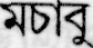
মচাবু
